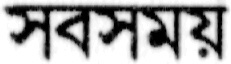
সবসময়
